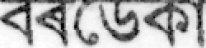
বৰডেকা
